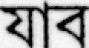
যাব
